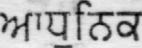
ਆਧੁਨਿਕ
